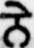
ਨੇ
